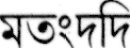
মতংদদি
